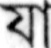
যা
